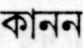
কানন
